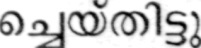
ച്ചെയ്തിട്ടു
